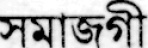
সমাজগী
